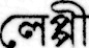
লেপ্পী
